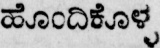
ಹೊಂದಿಕೊಳ್ಳ
